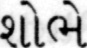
શોભે
